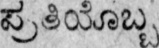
ಪ್ರತಿಯೊಬ್ಬ
